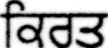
ਕਿਰਤ
